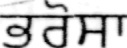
ਭਰੋਸਾ
